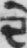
ਦੇ
